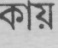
কায়
